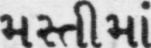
મસ્તીમાં
